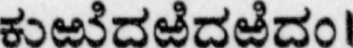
ಕುಱದಱದಱದಂ|
